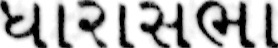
ધારાસભા
